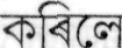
কৰিলে
